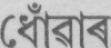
ধোঁৱাৰ
